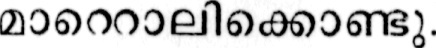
മാറ്റൊലിക്കൊണ്ടു.
